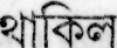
থাকিল
